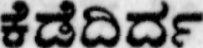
ಕೆಡೆದಿರ್ದ
